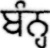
ਬੰਨ੍ਹ
